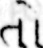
તો
